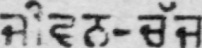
ਜੀਵਨ-ਚੱਜ
